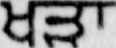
ਖੜਾ
